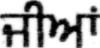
ਜੀਆਂ
